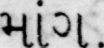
માંગ.
